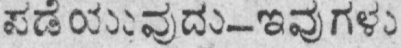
ಪಡೆಯುವುದು-ಇವುಗಳು
